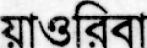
য়াওরিবা
